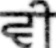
ਵੀ
